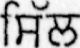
ਸਿੱਲ
